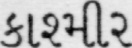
કાશ્મીર
